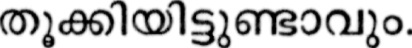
തൂക്കിയിട്ടുണ്ടാവും.
